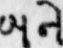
બને
